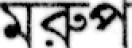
মরুপ
